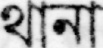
থানা
